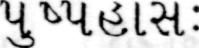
પુષ્પહાસઃ
